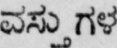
ವಸ್ತುಗಳ
